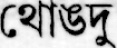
থোঙদু
